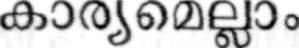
കാര്യമെല്ലാം
